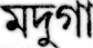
মদুগা
